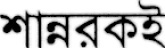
শান্নরকই
